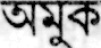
অমুক
